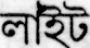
লাইট
